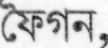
ফৈগন,
